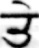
ਤੇ
